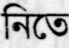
নিতে
